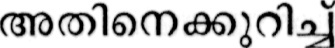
അതിനെക്കുറിച്ച്
